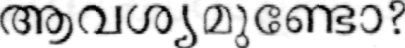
ആവശ്യമുണ്ടോ?
